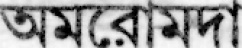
অমরোমদা
